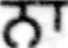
ਨਾ
